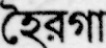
হৈরগা
